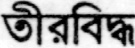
তীরবিদ্ধ
